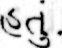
હતું.
